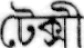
টেক্সী
